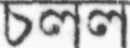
চলল
